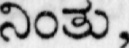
ನಿಂತು,
